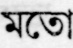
মতো
